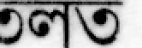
তলত
